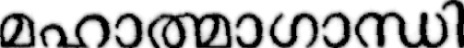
മഹാത്മാഗാന്ധി
